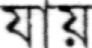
যায়
